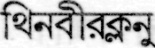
থিনবীরক্লনু
